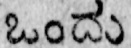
ಒಂದು
